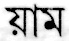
য়াম
